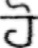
ਹੋ
